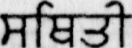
ਸਥਿਤੀ
